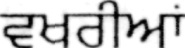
ਵਖਰੀਆਂ
